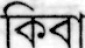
কিবা
